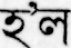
হ'ল
